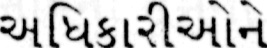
અધિકારીઓને
